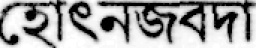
হোৎনজবদা
